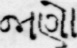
જાણો
